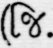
(જિ.
